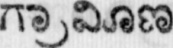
ಗ್ರಾಮೀಣ
